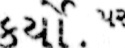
કર્યો.૫૨
